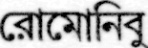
রোমোনিবু
